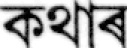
কথাৰ
